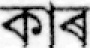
কাৰ
